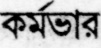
কর্মভার
